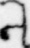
ને
